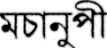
মচানুপী
